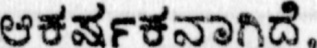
ಆಕರ್ಷಕವಾಗಿದೆ.
